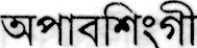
অপাবশিংগী
